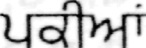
ਪਕੀਆਂ
